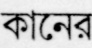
কানের
